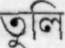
তুলি
